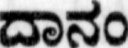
ದಾನಂ
